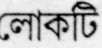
লোকটি
